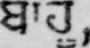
ਬਾਹੂ,
